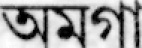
অমগা
